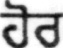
ਹੋਰ
